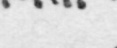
માનતો
